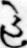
હે
